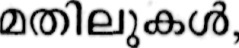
മതിലുകള്‍,
